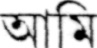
আমি
